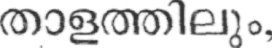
താളത്തിലും,
